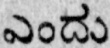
ಎಂದು
